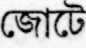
জোটে
